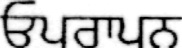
ਓਪਰਾਪਨ
